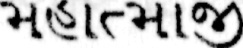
મહાત્માજી
